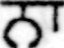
ਨਾ
